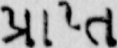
પ્રાપ્ત
